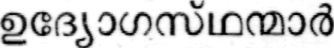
ഉദ്യോഗസ്ഥന്മാര്‍
